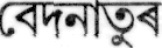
বেদনাতুৰ
